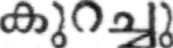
കുറച്ചു
